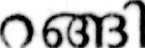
റങ്ങി
